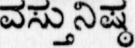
ವಸ್ತುನಿಷ್ಠ
